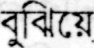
বুঝিয়ে
